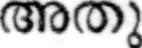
അതു
